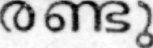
രണ്ടു
